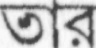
তার
